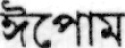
ঈপোম
